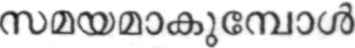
സമയമാകുമ്പോള്‍
